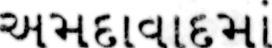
અમદાવાદમાં
